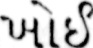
ખોઈ
